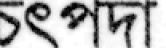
চৎপদা
